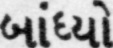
બાંધ્યો
